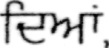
ਦਿਆਂ,
